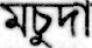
মচুদা
